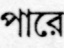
পারে
